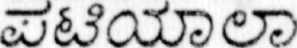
ಪಟಿಯಾಲಾ
